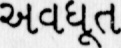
અવધૂત
